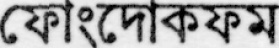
ফোংদোকফম
